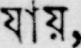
যায়,
